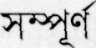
সম্পূর্ণ
